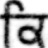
ਕਿ
